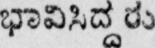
ಭಾವಿಸಿದ್ದರು
